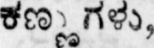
ಕಣ್ಣುಗಳು,
